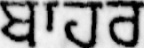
ਬਾਹਰ
